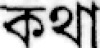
কথা
